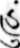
હું
